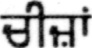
ਚੀਜ਼ਾਂ
